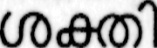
ശക്തി
